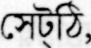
সেট্ঠি,
